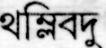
থম্লিবদু
